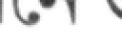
এনে
